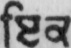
ਇਕ
